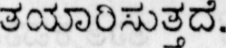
ತಯಾರಿಸುತ್ತದೆ.
